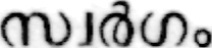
സ്വര്‍ഗം
